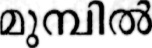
മുമ്പില്‍
